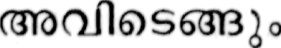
അവിടെങ്ങും
